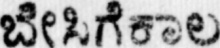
ಬೇಸಿಗೆಕಾಲ
